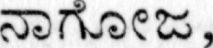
ನಾಗೋಜ,
